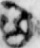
છે
